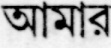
আমার
